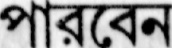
পারবেন
